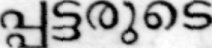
പ്പട്ടരുടെ
